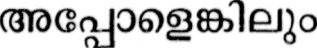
അപ്പോളെങ്കിലും
